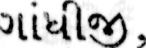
ગાંધીજી,
